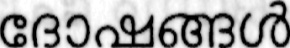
ദോഷങ്ങള്‍
